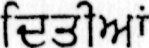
ਦਿਤੀਆਂ
